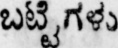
ಬಟ್ಟೆಗಳು
